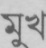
মুখ
